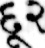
દૂર
